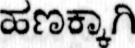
ಹಣಕ್ಕಾಗಿ
